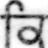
ਕਿ
